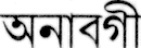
অনাবগী
